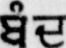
ਬੰਦ
